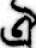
ঐ
